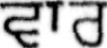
ਵਾਰ
